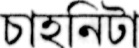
চাহনিটা
